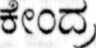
ಕೇಂದ್ರ
